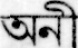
অনী
